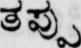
ತಪ್ಪು
